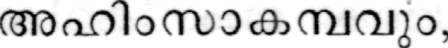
അഹിംസാകമ്പവും,
